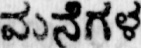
ಮನೆಗಳ
